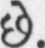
છે.
